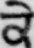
ਕੇ
